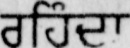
ਰਹਿੰਦਾ
